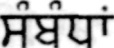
ਸੰਬੰਧਾਂ
